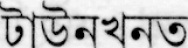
টাউনখনত
